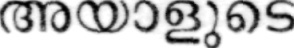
അയാളുടെ
